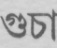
গুচা
